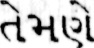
તેમણે
